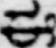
ಈ
